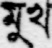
মুখ
